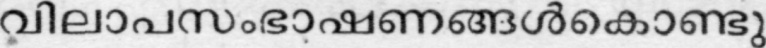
വിലാപസംഭാഷണങ്ങള്‍കൊണ്ടു
